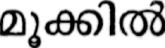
മൂക്കില്‍
